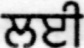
ਲਈ
